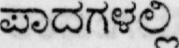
ಪಾದಗಳಲ್ಲಿ
